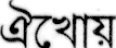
ঐখোয়
